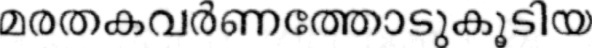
മരതകവര്‍ണത്തോടുകൂടിയ
